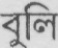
বুলি
